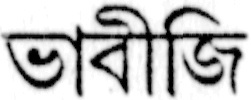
ভাবীজি
